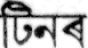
টিনৰ
